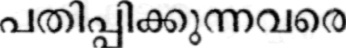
പതിപ്പിക്കുന്നവരെ
